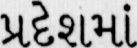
પ્રદેશમાં
